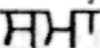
ਸਮਾਂ
